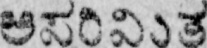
ಅಪರಿಮಿತ
